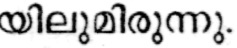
യിലുമിരുന്നു.
